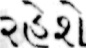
રહેશે
